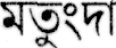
মতুংদা
